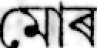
মোৰ
